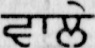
ਵਾਲੇ
